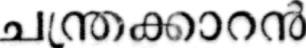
ചന്ത്രക്കാറന്‍
